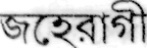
জহেরাগী
